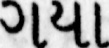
ગયા
